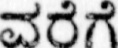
ವರೆಗೆ
